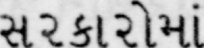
સરકારોમાં
